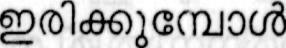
ഇരിക്കുമ്പോള്‍
